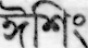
ঈশিং
